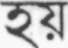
হয়
